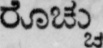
ರೊಚ್ಚು
